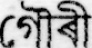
গৌৰী
